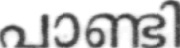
പാണ്ടി
